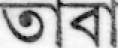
তাবা
